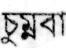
চুম্লবা
